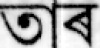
তাৰ
